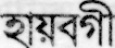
হায়বগী
